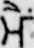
ਮੈਂ
